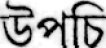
উপচি
